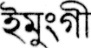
ইমুংগী
